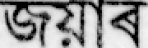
জয়াৰ
